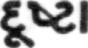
દૂષ્ટા
